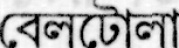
বেলটোলা
